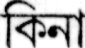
কিনা
